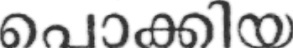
പൊക്കിയ
